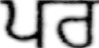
ਪਰ
